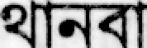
থানবা
